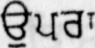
ਉਪਰਾ
